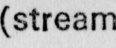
(stream
